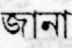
জানা
